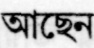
আছেন
